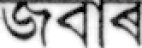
জবাৰ
